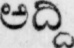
ಅದ್ದಿ
